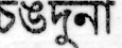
চঙদুনা
